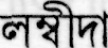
লম্বীদা
